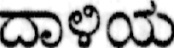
ದಾಳಿಯ
